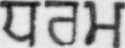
ਧਰਮ
